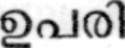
ഉപരി
